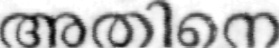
അതിനെ
